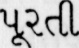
પૂરતી
